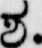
ಶ.
